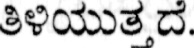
ತಿಳಿಯುತ್ತದೆ.
